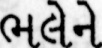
ભલેને
